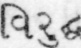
વિરુદ્ધ
